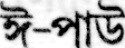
ঈ-পাউ
